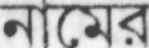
নামের
